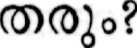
തരും?
